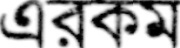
এরকম
